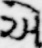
એ
